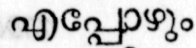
എപ്പോഴും
